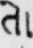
તો
